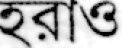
হরাও
